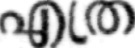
എത്ര
